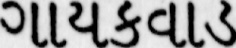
ગાયકવાડ
